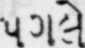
પગલે
